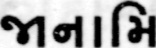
જાનામિ
